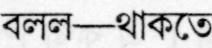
বলল–থাকতে
